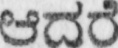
ಆದರೆ
